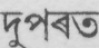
দুপৰত
